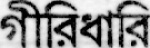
গীরিধারি
